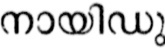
നായിഡു
